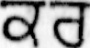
ਕਰ
